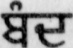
ਬੰਦ
